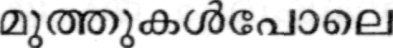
മുത്തുകള്‍പോലെ
